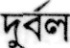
দুর্বল
